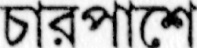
চারপাশে
